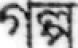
গল্প
